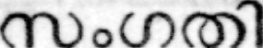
സംഗതി
